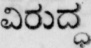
ವಿರುದ್ಧ
